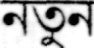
নতুন
